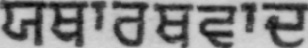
ਯਥਾਰਥਵਾਦ
